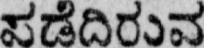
ಪಡೆದಿರುವ
